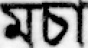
মচা
